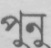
পুনু
